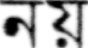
নয়
